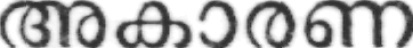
അകാരണ
